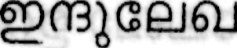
ഇന്ദുലേഖ
